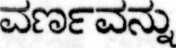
ವರ್ಣವನ್ನು
